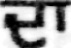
ਦਾ
